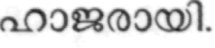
ഹാജരായി.
